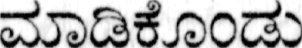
ಮಾಡಿಕೊಂಡು
